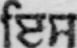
ਇਸ
